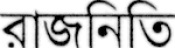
রাজনিতি
